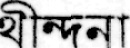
থীন্দনা
